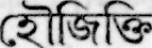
হৌজিক্তি
